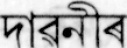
দাৱনীৰ
